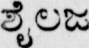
ಶೈಲಜ
